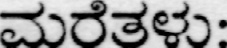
ಮರೆತಳು:
